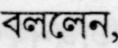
বললেন,
